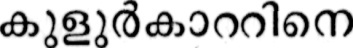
കുളുര്‍കാററിനെ
